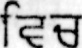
ਵਿਚ
